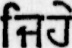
ਜਿਹੇ
